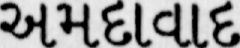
અમદાવાદ
